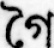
গৈ
